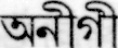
অনীগী
